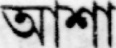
আশা
